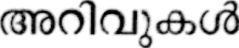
അറിവുകള്‍
